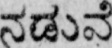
ನಡುವೆ
